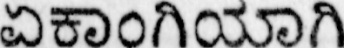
ಏಕಾಂಗಿಯಾಗಿ
